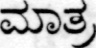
ಮಾತ್ರ
